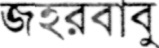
জহরবাবু
